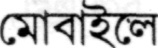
মোবাইলে
